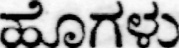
ಹೊಗಳು
